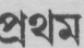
প্ৰথম
